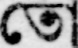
তো
